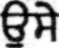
ਉਸੇ
